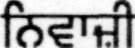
ਨਿਵਾਜ਼ੀ
